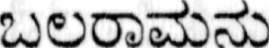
ಬಲರಾಮನು
